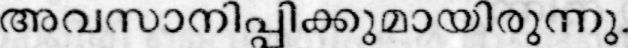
അവസാനിപ്പിക്കുമായിരുന്നു.
